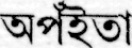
অপঁইতা
